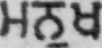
ਮਨੁਖ
